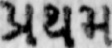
પ્રથમ
